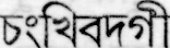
চংখিবদগী
